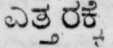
ಎತ್ತರಕ್ಕೆ
